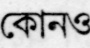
কোনও
